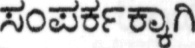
ಸಂಪರ್ಕಕ್ಕಾಗಿ
